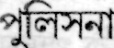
পুলিসনা
